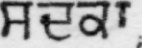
ਸਦਕਾ,
